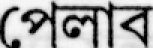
পেলাব
